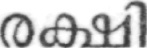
രക്ഷി
